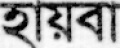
হায়বা
